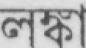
লঙ্কা
